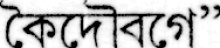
কৈদৌবগে”
